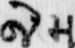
જેમ
